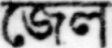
জেল
